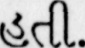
હતી.
